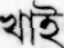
খাই
